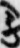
કે
